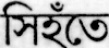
সিহঁতে
